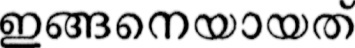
ഇങ്ങനെയായത്
